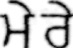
ਮੇਰੇ
